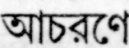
আচরণে
